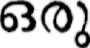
ഒരു
